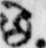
છે.
